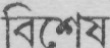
বিশেষ
